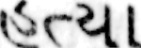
હત્યા
